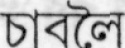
চাবলৈ
